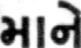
માને
